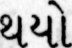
થયો
